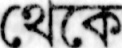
থেকে
